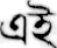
এই
